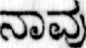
ನಾವು
